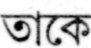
তাকে
